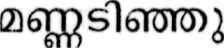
മണ്ണടിഞ്ഞു
